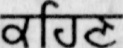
ਕਹਿਣ
